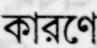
কারণে
